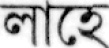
লাহে
